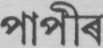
পাপীৰ
